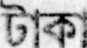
টাকা
